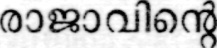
രാജാവിന്റെ
